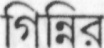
গিন্নির
